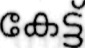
കേട്ട്
